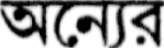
অন্যের
